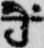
ਹੈਂ
